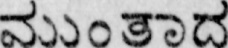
ಮುಂತಾದ
